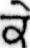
ਕੇ
